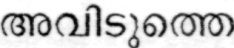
അവിടുത്തെ
